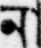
না
